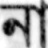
না
